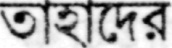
তাহাদের
